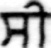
ਸੀ
